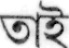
তাই
